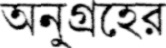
অনুগ্রহের
